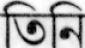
তিনি
